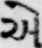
એ
